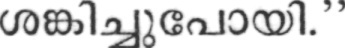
ശങ്കിച്ചുപോയി."
